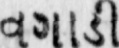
વગાડી
